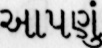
આપણું
